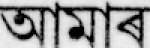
আমাৰ
